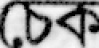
চেক
